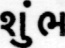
શુંભ
